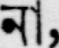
না,
